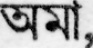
অমা,
